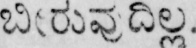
ಬೀರುವುದಿಲ್ಲ.
